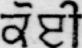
ਕੋਈ
